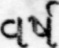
વર્ષ
